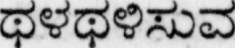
ಥಳಥಳಿಸುವ
